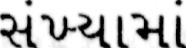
સંખ્યામાં
